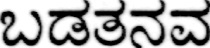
ಬಡತನವ
